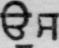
ਉਸ
